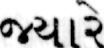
જ્યારે
